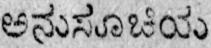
ಅನುಸೂಚಿಯ
